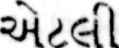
એટલી
